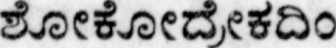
ಶೋಕೋದ್ರೇಕದಿಂ
